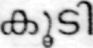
കൂടി
